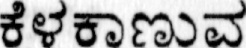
ಕೆಳಕಾಣುವ
